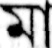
মা
